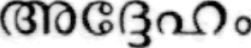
അദ്ദേഹം
